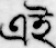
এই
